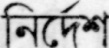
নির্দেশ
